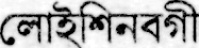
লোইশিনবগী
